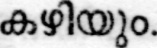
കഴിയും.
